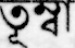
তূম্বা
